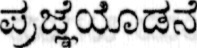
ಪ್ರಜ್ಞೆಯೊಡನೆ
